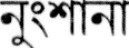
নুংশানা
